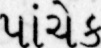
પાંચેક
